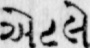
એટલે
